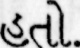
હતો.
